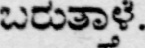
ಬರುತ್ತಾಳೆ.
